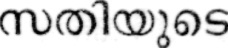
സതിയുടെ
